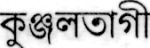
কুঞ্জলতাগী
